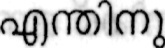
എന്തിനു
